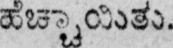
ಹೆಚ್ಚಾಯಿತು.
